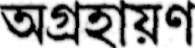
অগ্রহায়ণ
